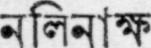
নলিনাক্ষ
